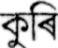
কুৰি
